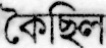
কৈছিল
